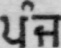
ਪੰਜ
